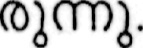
രുന്നു.
